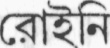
রোইনি
